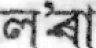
ল'ৰা
